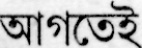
আগতেই
